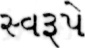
સ્વરૂપે
